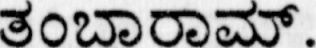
ತಂಬಾರಾಮ್.
